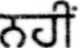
ਨਹੀਂ
